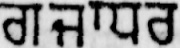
ਗਜਾਧਰ
